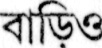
বাড়িও
